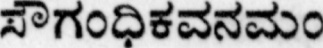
ಸೌಗಂಧಿಕವನಮಂ
